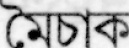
মৈচাক
